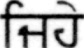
ਜਿਹੇ
